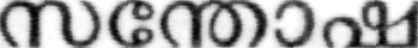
സന്തോഷ
